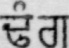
ਢੰਗ
